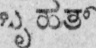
ಬೃಹತ್
